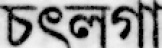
চৎলগা
